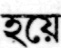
হয়ে
